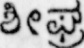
ಶೀಘ್ರ
